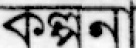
কল্পনা
